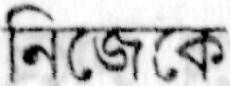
নিজেকে
